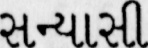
સન્યાસી
